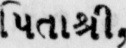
પિતાશ્રી,
